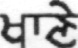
ਖਾਣੇ
